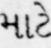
માટે
